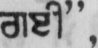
ਗਈ'',
